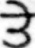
ਤੇ
